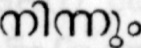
നിന്നും
